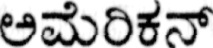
ಅಮೆರಿಕನ್
